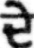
ਦੇ
